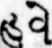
હવે
